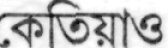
কেতিয়াও
